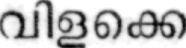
വിളക്കെ
